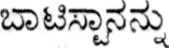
ಬಾಟಿಸ್ಟಾನನ್ನು
